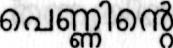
പെണ്ണിന്റെ
